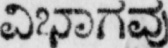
ವಿಭಾಗವು
